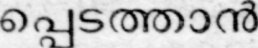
പ്പെടത്താന്‍
